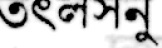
তৎলসনু
